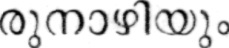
രുനാഴിയും
